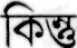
কিন্তু
